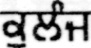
ਕੁਲੰਜ
